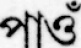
পাওঁ
